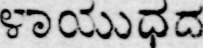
ಳಾಯುಧದ
